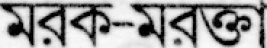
মরক-মরক্তা
